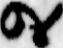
જ
